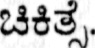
ಚಿಕಿತ್ಸೆ.
